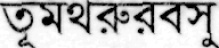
তুমথরুরবসু
